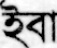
ইবা
